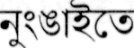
নুংঙাইতে
